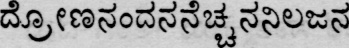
ದ್ರೋಣನಂದನನೆಚ್ಚನನಿಲಜನ
